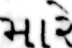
મારે
